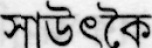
সাউৎকৈ
